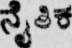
ನೈತಿಕ
